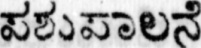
ಪಶುಪಾಲನೆ
